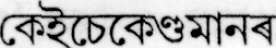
কেইচেকেণ্ডমানৰ
